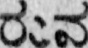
ರುವ
